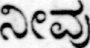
ನೀವು
